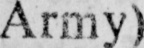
Army)
